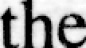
the
